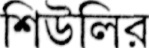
শিউলির
